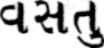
વસતુ
